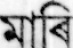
মাৰি
